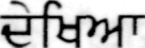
ਦੇਖਿਆ
